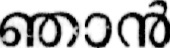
ഞാന്‍
